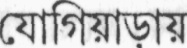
যোগিয়াড়ায়
